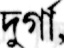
দুর্গা,
